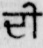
ਦੀ
